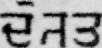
ਦੋਸਤ
